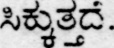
ಸಿಕ್ಕುತ್ತದೆ.
